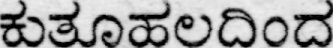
ಕುತೂಹಲದಿಂದ
